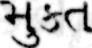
મુક્ત
